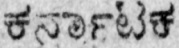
ಕರ್ನಾಟಕ
